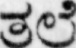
ತಲೆ
